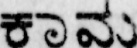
ಕಾಮ
